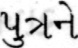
પુત્રને
